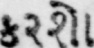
કરશો
